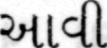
આવી
